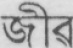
জীৱ
